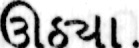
ઊઠ્યા.
